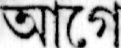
আগে
